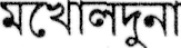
মখোলদুনা
